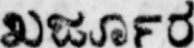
ಖರ್ಜೂರ
